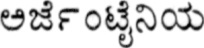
ಅರ್ಜೆಂಟೈನಿಯ
